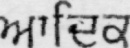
ਆਦਿਕ
